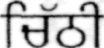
ਚਿੱਠੀ
